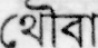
থৌবা
